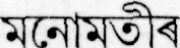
মনোমতীৰ
